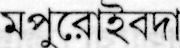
মপুরোইবদা
